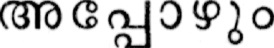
അപ്പോഴും
